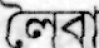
লৈবা
